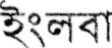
ইংলবা
